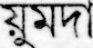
য়ুমদা
